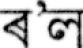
ৰ'ল
